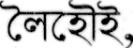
লৈহৌই,
